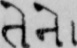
તેનો
